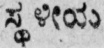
ಸ್ಥಳೀಯ
